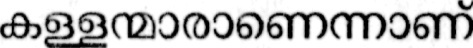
കള്ളന്മാരാണെന്നാണ്
